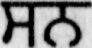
ਸਨ
